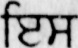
ਇਸ
